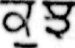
ਕੁਝ
